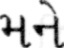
મને
